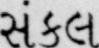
સંકલ
